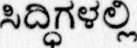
ಸಿದ್ಧಿಗಳಲ್ಲಿ
